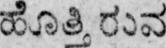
ಹೊತ್ತಿರುವ
